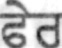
ਫੇਰ
